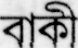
বাকী
